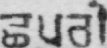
ਛਪਰੀ
